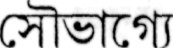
সৌভাগ্যে
